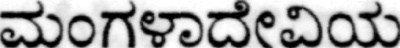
ಮಂಗಳಾದೇವಿಯ
